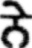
ਨੇ
